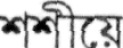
শশীয়ে
